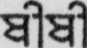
ਬੀਬੀ
